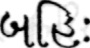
બહિઃ
